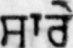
ਸਾਰੇ
